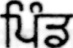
ਪਿੰਡ
